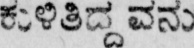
ಕುಳಿತಿದ್ದವನು
